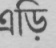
এড়ি
